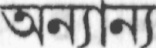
অন্যান্য
